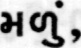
મળું,
